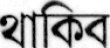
থাকিব
